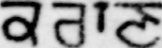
ਕਰਾਣ
